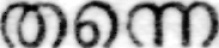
തന്നെ
